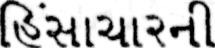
હિંસાચારની
